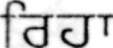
ਰਿਹਾ
